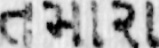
તમારા
